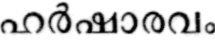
ഹര്‍ഷാരവം
